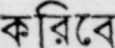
করিবে
